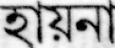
হায়না
